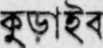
কুড়াইব
